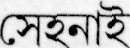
সেহনাই
